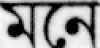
মনে
